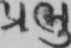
પ્રભુ
